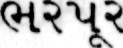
ભરપૂર
